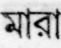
মারা
